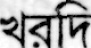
খরদি
